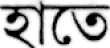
হাতে
